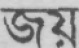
জয়
